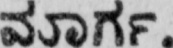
ಮಾರ್ಗ.
